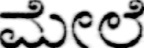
ಮೇಲೆ
